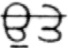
ਉਤੇ
